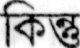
কিন্তু
